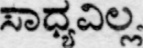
ಸಾಧ್ಯವಿಲ್ಲ.
